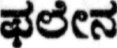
ಫಲೇನ
